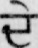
ਦੇ
